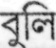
বুলি
